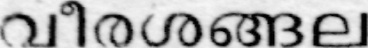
വീരശങ്ങല
